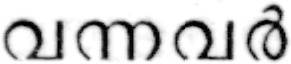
വന്നവര്‍
